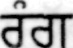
ਰੰਗ
